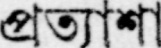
প্রত্যাশা
